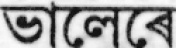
ভালেৰে
